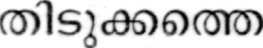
തിടുക്കത്തെ
